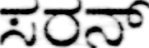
ಸರನ್
